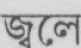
জ্বলে
